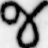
જ
